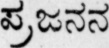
ಪ್ರಜನನ
